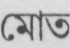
মোত
